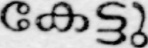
കേട്ടു
